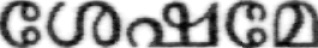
ശേഷമേ
